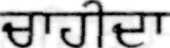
ਚਾਹੀਦਾ
